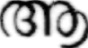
ആ
